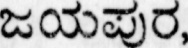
ಜಯಪುರ,
